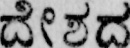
ದೇಶದ
